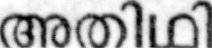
അതിഥി
